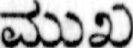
ಮುಖ
